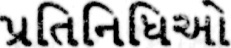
પ્રતિનિધિઓ
